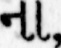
ના,
